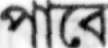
পাবে
